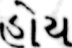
હોય
